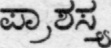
ಪ್ರಾಶಸ್ತ್ಯ
